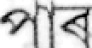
পাৰ
